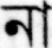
না
